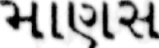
માણસ
